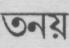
তনয়
